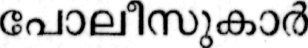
പോലീസുകാര്‍
